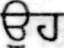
ਉਹ
